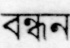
বন্ধন
